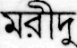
মরীদু
